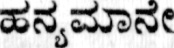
ಹನ್ಯಮಾನೇ
